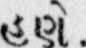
હણે.
